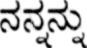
ನನ್ನನ್ನು
